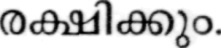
രക്ഷിക്കും.
